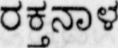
ರಕ್ತನಾಳ
